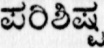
ಪರಿಶಿಷ್ಟ
